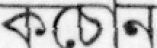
কচোন
